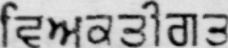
ਵਿਅਕਤੀਗਤ
